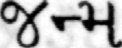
જન્મ
